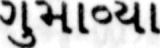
ગુમાવ્યા
